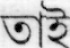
তাই
